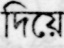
দিয়ে
